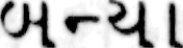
બન્યા
